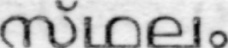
സ്ഥലം
